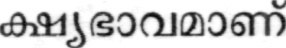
ക്ഷ്യഭാവമാണ്
